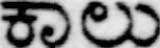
ಕಾಲು
